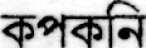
কপকনি
